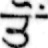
ਤੋਂ
